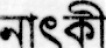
নাৎকী
